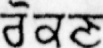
ਰੋਕਣ
